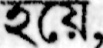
হয়ে,
